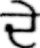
ਦੇ
